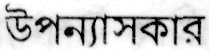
উপন্যাসকার
